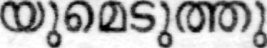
യുമെടുത്തു
